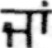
ਜਾਂ
